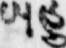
બહુ
